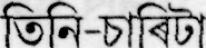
তিনি-চাৰিটা
